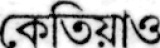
কেতিয়াও
